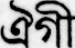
ঐগী
